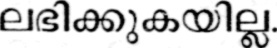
ലഭിക്കുകയില്ല.
